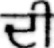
ਦੀ
